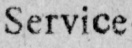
Service
